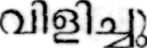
വിളിച്ചു
